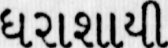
ધરાશાયી
